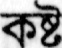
কষ্ট
